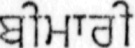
ਬੀਮਾਰੀ
